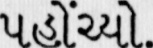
પહોંચ્યો.
